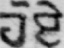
ਹੋਏ
